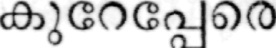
കുറേപ്പേരെ
